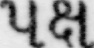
પક્ષ
